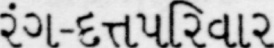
રંગ-દત્તપરિવાર
